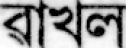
ৱাখল
